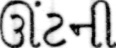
ઊંટની
